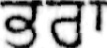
ਭਰਾ
